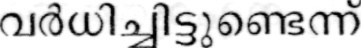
വര്‍ധിച്ചിട്ടുണ്ടെന്ന്
